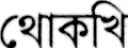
থোকখি
